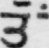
ਤੋਂ
